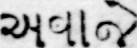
અવાજે
